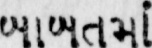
બાબતમાં
